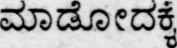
ಮಾಡೋದಕ್ಕೆ
